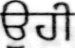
ਉਹੀ
